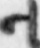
ન
